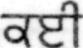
ਕਈ
